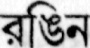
রঙিন
